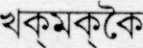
খক্‌মক্‌কৈ
